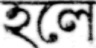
হলে
